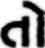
તો
